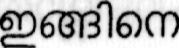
ഇങ്ങിനെ
